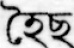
হৈছ
